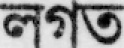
লগত
